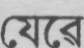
যেৱে
